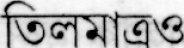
তিলমাত্রও
